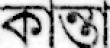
কান্তা
